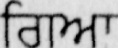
ਗਿਆ
